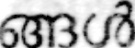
ങ്ങള്‍
